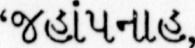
'જહાંપનાહ,
